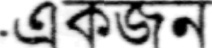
একজন
